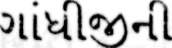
ગાંધીજીની
